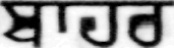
ਬਾਹਰ
